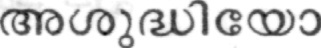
അശുദ്ധിയോ
